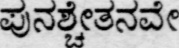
ಪುನಶ್ಚೇತನವೇ
